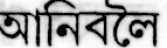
আনিবলৈ
